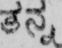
ತನ್ನ
